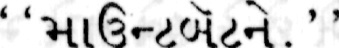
"માઉન્ટબૅટને."
